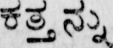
ಕತ್ತನ್ನು
